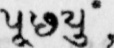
પૂછ્યું,
